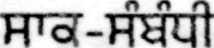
ਸਾਕ-ਸੰਬੰਧੀ
